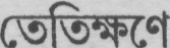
তেতিক্ষণে
